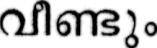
വീണ്ടും
